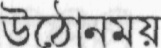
উঠোনময়
